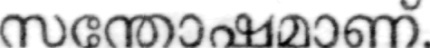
സന്തോഷമാണ്.
